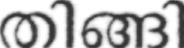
തിങ്ങി
